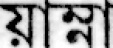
য়াম্না
